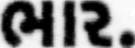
ભાર.
